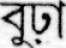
বুঢ়া
